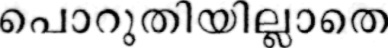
പൊറുതിയില്ലാതെ
